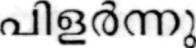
പിളര്‍ന്നു
